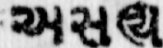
અસહ્ય
